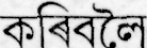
কৰিবলৈ
